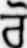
ਰੋ
